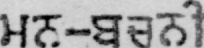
ਮਨ-ਬਚਨੀ
